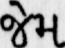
જેમ
